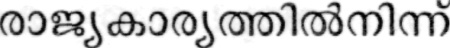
രാജ്യകാര്യത്തില്‍നിന്ന്
